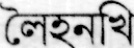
লৈহনখি
